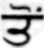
ਤੋਂ
